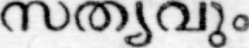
സത്യവും
